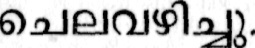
ചെലവഴിച്ചു.
